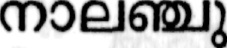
നാലഞ്ചു
